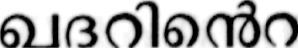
ഖദറിന്റെ
